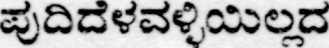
ಪುದಿದೆಳವಳ್ಳಿಯಿಲ್ಲದ
